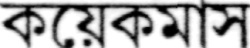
কয়েকমাস
